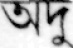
অদু
